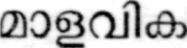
മാളവിക
